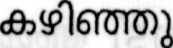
കഴിഞ്ഞു
